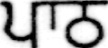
ਪਾਠ
